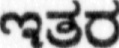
ಇತರ
